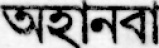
অহানবা
